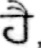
ਹੈ,
